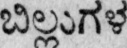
ಬಿಲ್ಲುಗಳ
